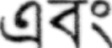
এবং
